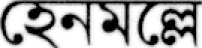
হেনমল্লে
